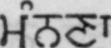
ਮੰਨਣਾ
